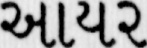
આયર
